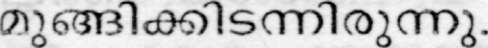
മുങ്ങിക്കിടന്നിരുന്നു.
